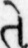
તે
